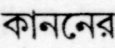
কাননের
